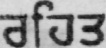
ਰਹਿਤ
